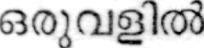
ഒരുവളില്‍
